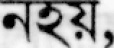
নহয়,
